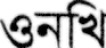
ওনখি
